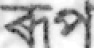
ৰূপ
